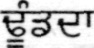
ਢੂੰਡਦਾ
